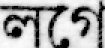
লগে
